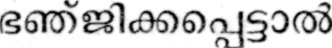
ഭഞ്ജിക്കപ്പെട്ടാല്‍
